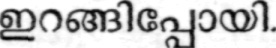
ഇറങ്ങിപ്പോയി.
